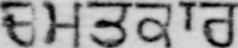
ਚਮਤਕਾਰ
